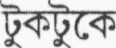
টুকটুকে
